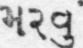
મરવું
